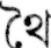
থৈ
